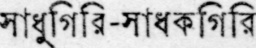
সাধুগিরি-সাধকগিরি
